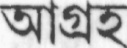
আগ্রহ
